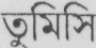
তুমিসি
